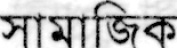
সামাজিক
